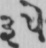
રૂપે
